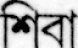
শিবা
